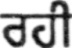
ਰਹੀ
